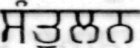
ਸੰਤੁਲਨ
